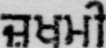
ਜ਼ਖਮੀ
